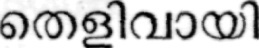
തെളിവായി
